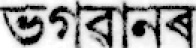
ভগৱানৰ
